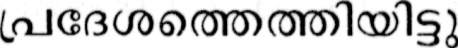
പ്രദേശത്തെത്തിയിട്ടു
